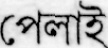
পেলাই
